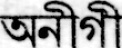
অনীগী
